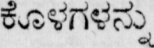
ಕೊಳಗಳನ್ನು
